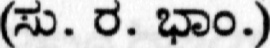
(ಸು.ರ.ಭಾಂ.)
